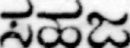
ಸಹಜ
